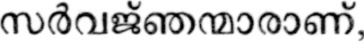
സര്‍വജ്ഞന്മാരാണ്,
